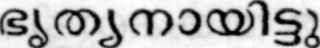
ഭൃത്യനായിട്ടു
